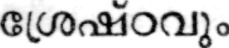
ശ്രേഷ്ഠവും
